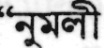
"নুমলী
